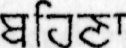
ਬਹਿਣਾ
